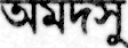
অমদসু
